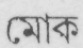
মোক
